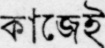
কাজেই
